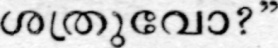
ശത്രുവോ?''
